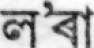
ল'ৰা
